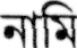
নামি
